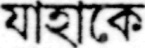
যাহাকে
